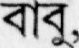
বাবু,
